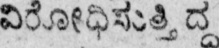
ವಿರೋಧಿಸುತ್ತಿದ್ದ
